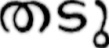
തടു
